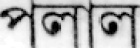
পলাল
